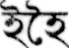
ইহৈ
